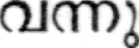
വന്നു
